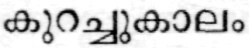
കുറച്ചുകാലം
